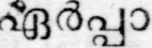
ഏര്‍പ്പാ
